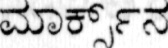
ಮಾರ್ಕ್ಸ್‌ನ
